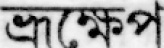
ভ্রূক্ষেপ
